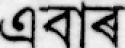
এবাৰ
